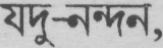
যদু-নন্দন,
